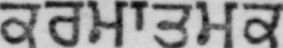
ਕਰਮਾਤਮਕ
